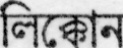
লিক্কোন
